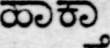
ಹಾಕ್ತಾ
